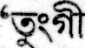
‘তুংগী
